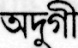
অদুগী
